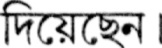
দিয়েছেন।
